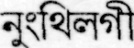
নুংথিলগী
